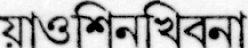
য়াওশিনখিবনা
